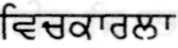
ਵਿਚਕਾਰਲਾ
